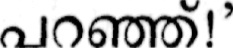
പറഞ്ഞ്!'
